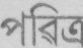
পৱিত্র
